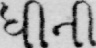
ધીની
